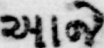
આજે
